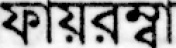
ফায়রম্বা
